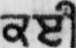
ਕਈ
